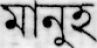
মানুহ
